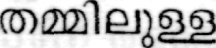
തമ്മിലുള്ള
